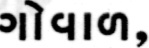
ગોવાળ,
